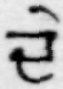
ਦੇ
